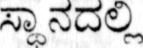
ಸ್ಥಾನದಲ್ಲಿ
